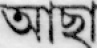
আছা
